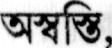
অস্বস্তি,
